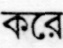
করে
